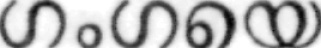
ഗംഗയെ
